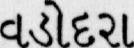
વડોદરા
